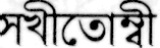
সখীতোম্বী
